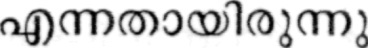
എന്നതായിരുന്നു
